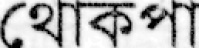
থোকপা
